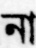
না
